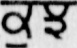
ਕੁਝ
